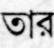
তার
